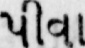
પીવા
